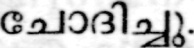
ചോദിച്ചു.
